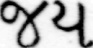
જય
